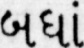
બધાં
